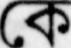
কে
